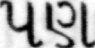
પણ
